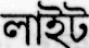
লাইট
